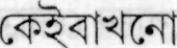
কেইবাখনো
